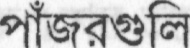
পাঁজরগুলি
